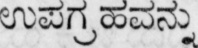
ಉಪಗ್ರಹವನ್ನು
